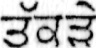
ਤੱਕੜੇ
